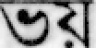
ভয়
